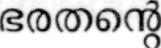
ഭരതന്റെ
